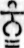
ਨੂੰ
